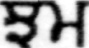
ਝਮ
